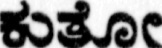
ಕುತೋ
